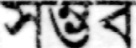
সম্ভব
